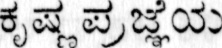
ಕೃಷ್ಣಪ್ರಜ್ಞೆಯ
